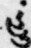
હું
